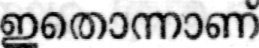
ഇതൊന്നാണ്
